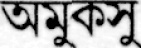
অমুকসু
